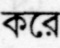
করে
